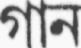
গান
